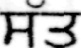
ਸੱਤ
